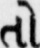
તો
